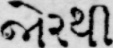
જોરથી
